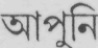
আপুনি
